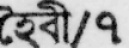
হৈবী/৭
